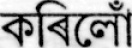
কৰিলোঁ
